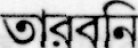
তারবনি
